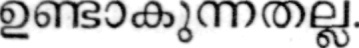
ഉണ്ടാകുന്നതല്ല.
